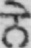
ਨੇ
